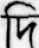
দি
